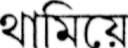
থামিয়ে
